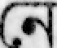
নে
